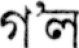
গ'ল
